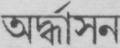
অর্দ্ধাসন
